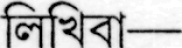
লিখিবা-
